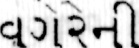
વગેરેની
